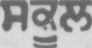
ਸਕੂਲ
